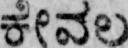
ಕೇವಲ
